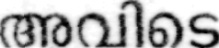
അവിടെ
